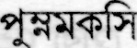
পুম্নমকসি
